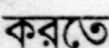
করতে
